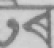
সম্ৰাটৰ
